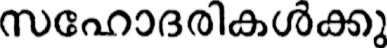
സഹോദരികള്‍ക്കു
